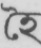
হৈ
